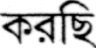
করছি
